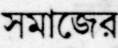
সমাজের
